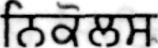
ਨਿਕੋਲਸ
